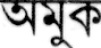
অমুক
